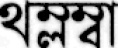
থম্লম্বা
